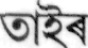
তাইৰ
